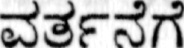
ವರ್ತನೆಗೆ
